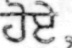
ਹੋਏ,
